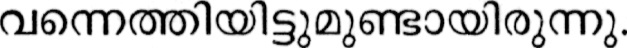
വന്നെത്തിയിട്ടുമുണ്ടായിരുന്നു.
